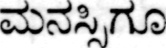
ಮನಸ್ಸಿಗೂ
